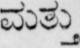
ಮತ್ತು
